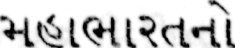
મહાભારતનો
